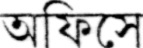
অফিসে
